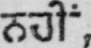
ਨਹੀਂ,
